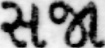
સજા
